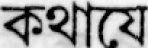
কথাযে
